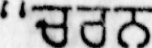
''ਚਰਨ
